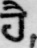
ਹੈ,
